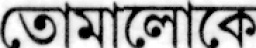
তোমালোকে
